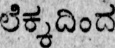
ಲೆಕ್ಕದಿಂದ
